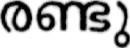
രണ്ടു
